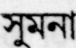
সুমনা
